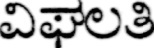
ವಿಘಲತಿ
